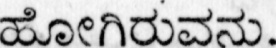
ಹೋಗಿರುವನು.
